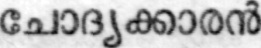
ചോദ്യക്കാരന്‍
